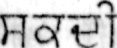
ਸਕਦੀ
